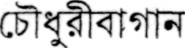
চৌধুরীবাগান
